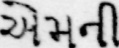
એમની
